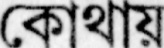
কোথায়
